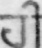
ਹੀ
